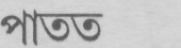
পাতত
